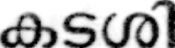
കടശി
